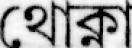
থোক্না
